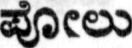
ಪೋಲು
